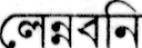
লেন্নবনি
